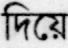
দিয়ে
